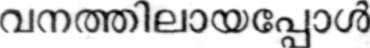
വനത്തിലായപ്പോള്‍
